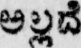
ಅಲ್ಲದೆ
